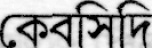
কেবসিদি
